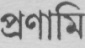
প্ৰণামি
